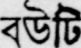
বউটি
